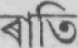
ৰাতি
